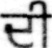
ਦੀ
